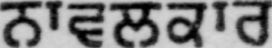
ਨਾਵਲਕਾਰ
